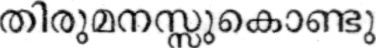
തിരുമനസ്സുകൊണ്ടു
